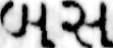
બસ
